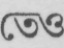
তেও
